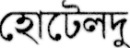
হোটেলদু
